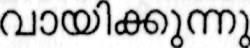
വായിക്കുന്നു
